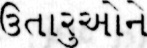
ઉતારુઓને
